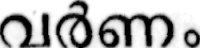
വര്‍ണം
